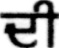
ਦੀ
